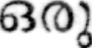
ഒരു
